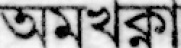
অমখক্না
